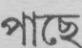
পাছে
